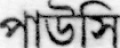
পাউসি
